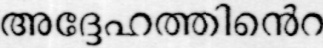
അദ്ദേഹത്തിന്റെ
